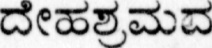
ದೇಹಶ್ರಮದ
